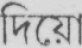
দিয়ো
